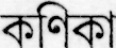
কণিকা
